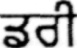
ਡਰੀ
